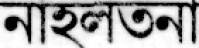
নাহলতনা
